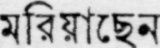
মরিয়াছেন
